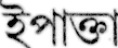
ইপাক্তা
